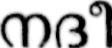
നദീ
